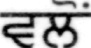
ਵਲੋਂ
